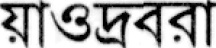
য়াওদ্রবরা
